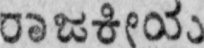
ರಾಜಕೀಯ
